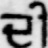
ਦੀ
